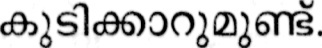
കുടിക്കാറുമുണ്ട്.
